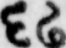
દ્દઢ
